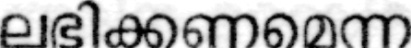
ലഭിക്കണമെന്ന
